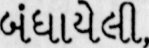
બંધાયેલી,
